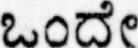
ಒಂದೇ
